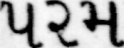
પરમ
